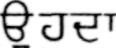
ਉਹਦਾ
